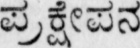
ಪ್ರಕ್ಷೇಪನ
